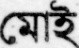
মোই
